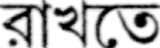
রাখতে
